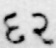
દર
